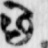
છે.
